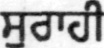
ਸੁਰਾਹੀ
